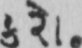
કરો.
